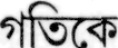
গতিকে
